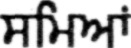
ਸਮਿਆਂ
